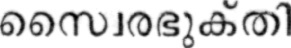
സ്വൈരഭുക്തി
